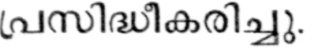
പ്രസിദ്ധീകരിച്ചു.
